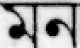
মন
